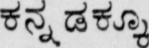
ಕನ್ನಡಕ್ಕೂ
